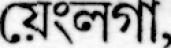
য়েংলগা,
